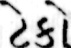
ટેકો
